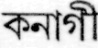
কনাগী
